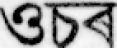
ওচৰ
